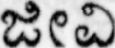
ಜೀವಿ
